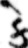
કે
